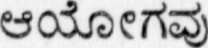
ಆಯೋಗವು
